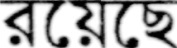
রয়েছে
